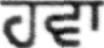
ਹਵਾ
